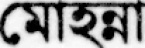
মোহন্না
